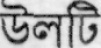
উলটি
